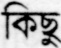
কিছু
